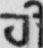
ਹੀ
